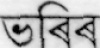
ভৰিৰ
